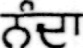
ਨੰਦਾ
